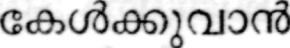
കേള്‍ക്കുവാന്‍
